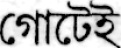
গোটেই
